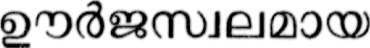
ഊര്‍ജസ്വലമായ
